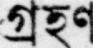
গ্রহণ
